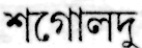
শগোলদু
